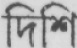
দিশি
